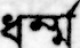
ধর্ম্ম
